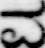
ವ
